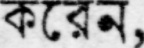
করেন,
